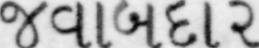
જવાબદાર
